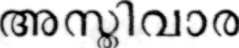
അസ്തിവാര
